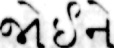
જોઈને
